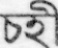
চহী
